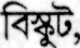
বিস্কুট,
